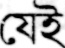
যেই
